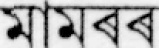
মামৰৰ
